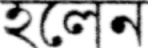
হলেন
